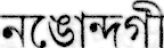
নঙোন্দগী
